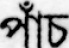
পাঁচ
